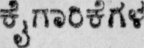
ಕೈಗಾರಿಕೆಗಳ
